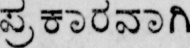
ಪ್ರಕಾರವಾಗಿ
